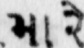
મારે
